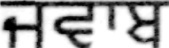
ਜਵਾਬ
